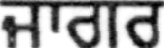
ਜਾਗਰ
